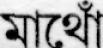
মাথোঁ
